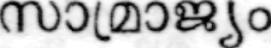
സാമ്രാജ്യം
